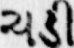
ચડી
